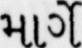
માર્ગે
